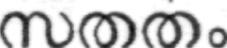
സതതം
